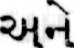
અને
